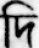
দি
